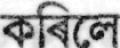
কৰিলে
